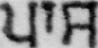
ਪਾਸ
